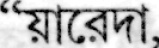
“য়ারেদা,
